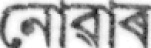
নোৱাৰ
